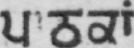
ਪਾਠਕਾਂ
